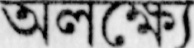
অলক্ষ্যে
